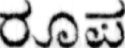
ರೂಪ
